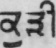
ਕੁੜੀ
